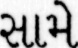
સામે
